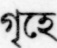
গৃহে
